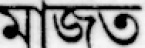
মাজত
